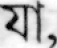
যা,
